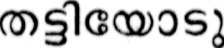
തട്ടിയോടു
